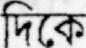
দিকে
